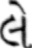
લે
